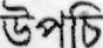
উপচি
